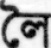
লৈ
